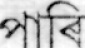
পাৰি
